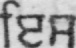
ਇਸ
